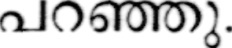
പറഞ്ഞു.
